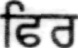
ਫਿਰ
